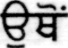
ਉਥੋਂ
